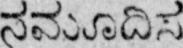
ನಮೂದಿಸ
